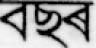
বছৰ
